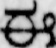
ಈ
